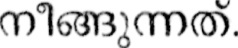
നീങ്ങുന്നത്.
